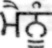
ਮੈਨੂੰ
